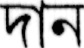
দান
